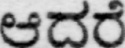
ಆದರೆ
